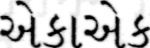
એકાએક
